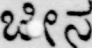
ಚೀನ
